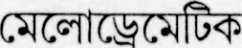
মেলোড্ৰেমেটিক
